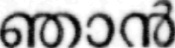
ഞാന്‍
